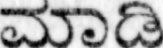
ಮಾಡಿ
